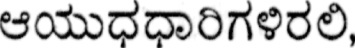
ಆಯುಧಧಾರಿಗಳಿರಲಿ,
